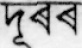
দূৰৰ
